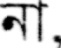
না,
